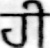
ਹੀ
